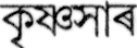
কৃষ্ণসাৰ
